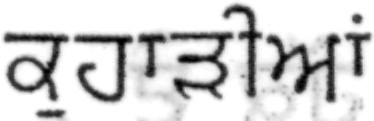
ਕੁਹਾੜੀਆਂ
